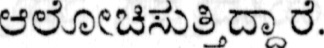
ಆಲೋಚಿಸುತ್ತಿದ್ದಾರೆ.
